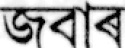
জবাৰ
